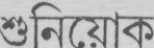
শুনিয়োক
